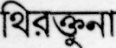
থিরক্তুনা
